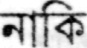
নাকি
